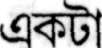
একটা
